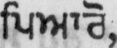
ਪਿਆਰੋ,
